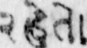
રહેતો
